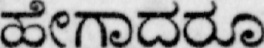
ಹೇಗಾದರೂ
